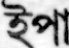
ইপা
